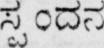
ಸ್ಪಂದನ
